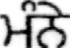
ਮੰਨੇ
